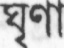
ঘৃণা
